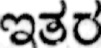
ಇತರ
